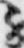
કે
